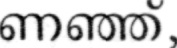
ണഞ്ഞ്,
